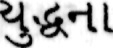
યુદ્ધના
